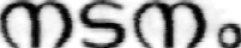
നടനം
